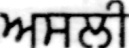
ਅਸਲੀ
